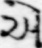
એ
